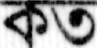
কত
